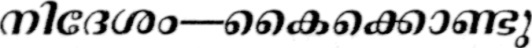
നിദേശം-കൈക്കൊണ്ടു
